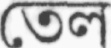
তেল
